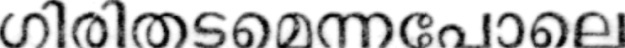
ഗിരിതടമെന്നപോലെ
